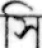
সি
